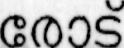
രോട്
